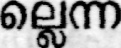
ല്ലെന്ന
